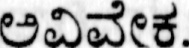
ಅವಿವೇಕ.
